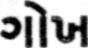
ગોખ
